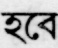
হবে
